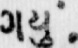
ગયું.
